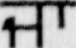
ਜਾ
